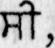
ਸੀ,
